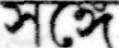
সঙ্গে
